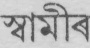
স্বামীৰ
